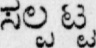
ಸಲ್ಪಟ್ಟ
